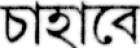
চাহাবে
